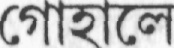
গোহালে
